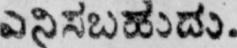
ಎನಿಸಬಹುದು.
